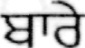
ਬਾਰੇ
